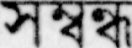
সম্বন্ধ
